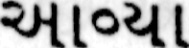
આવ્યા
